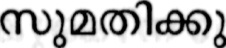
സുമതിക്കു
